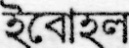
ইবোহল
